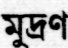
মুদ্রণ
